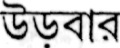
উড়বার
